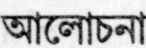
আলোচনা
